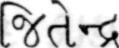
જિતેન્દ્ર
